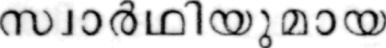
സ്വാര്‍ഥിയുമായ
